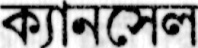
ক্যানসেল
